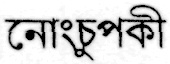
নোংচুপকী
